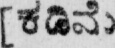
[ಕಡಿಮೆ
